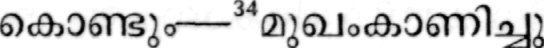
കൊണ്ടും-34മുഖംകാണിച്ചു
